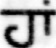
ਹਾਂ
